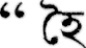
“হৈ
